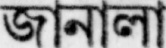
জানালা
